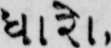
ધારો,
